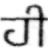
ਹੀ
